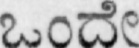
ಒಂದೇ
